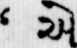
એ
